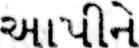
આપીને
